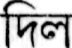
দিল
